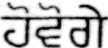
ਹੋਵੋਗੇ
